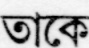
তাকে
